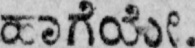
ಹಾಗೆಯೇ,
